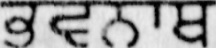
ਭਵਨਾਥ
